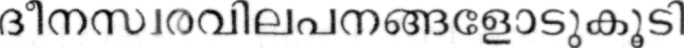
ദീനസ്വരവിലപനങ്ങളോടുകൂടി
